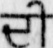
ਦੀ
